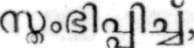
സ്തംഭിപ്പിച്ച്,
